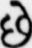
છે
